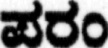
ಪರ೦
